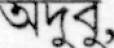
অদুবু,
